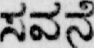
ಸವನೆ
